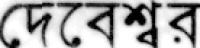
দেবেশ্বর
